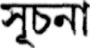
সূচনা
